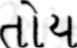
તોય
